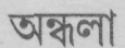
অন্ধলা
